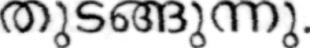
തുടങ്ങുന്നു.
